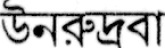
উনরুদ্রবা
